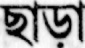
ছাড়া
